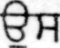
ਉਸ
